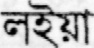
লইয়া
